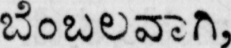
ಬೆಂಬಲವಾಗಿ,
